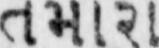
તમારા
